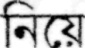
নিয়ে
